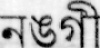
নঙগী
